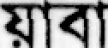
য়াবা
